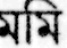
মম
